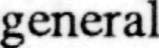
general
